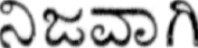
ನಿಜವಾಗಿ
